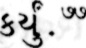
કર્યું.૭૭
